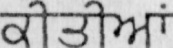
ਕੀਤੀਆਂ
